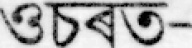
ওচৰত-
